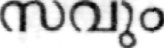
സവും
